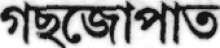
গছজোপাত
